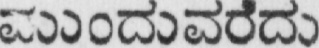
ಮುಂದುವರೆದು
